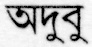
অদুবু
